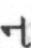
ન
